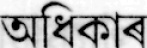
অধিকাৰ
